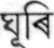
ঘূৰি
